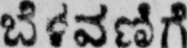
ಬೆಳವಣಿಗೆ
